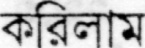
করিলাম
